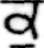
ਕੁ
